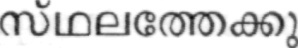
സ്ഥലത്തേക്കു
